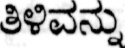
ತಿಳಿವನ್ನು
